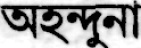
অহন্দুনা
